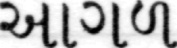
આગળ
